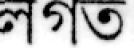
লগত
